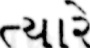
ત્યારે
